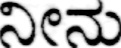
ನೀನು
